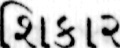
શિકાર
